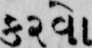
કરવો
